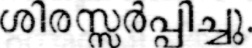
ശിരസ്സര്‍പ്പിച്ചു.
